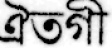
ঐতগী
